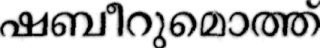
ഷബീറുമൊത്ത്
